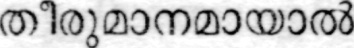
തീരുമാനമായാല്‍
